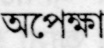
অপেক্ষা
